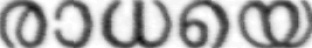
രാധയെ
